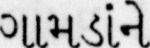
ગામડાંને
